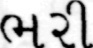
ભરી
